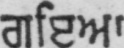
ਗਇਆ
